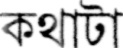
কথাটা
